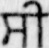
ਸੀ
